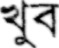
খুব
